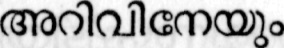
അറിവിനേയും
